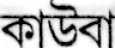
কাউবা
